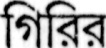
গিরির
